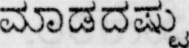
ಮಾಡದಷ್ಟು
